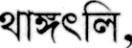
থাঙ্গৎলি,
